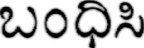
ಬಂಧಿಸಿ
